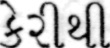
કેરીથી
